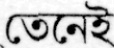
তেনেই
